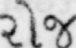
રોજ
